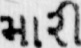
મારી
